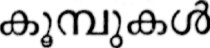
കൂമ്പുകള്‍
